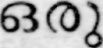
ഒരു
